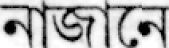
নাজানে
